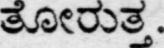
ತೋರುತ್ತ.
